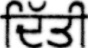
ਦਿੱਤੀ
